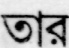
তার
